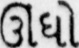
ઊંધો
